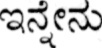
ಇನ್ನೇನು
